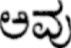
ಅವು
